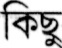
কিছু
